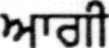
ਆਗੀ
